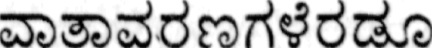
ವಾತಾವರಣಗಳೆರಡೂ
